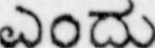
ಎಂದು
